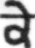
ਕੇ
